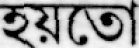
হয়তো
